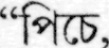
"পিচে,
